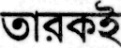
তারকই
